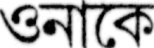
ওনাকে
